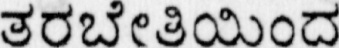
ತರಬೇತಿಯಿಂದ
